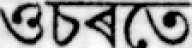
ওচৰতে
